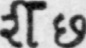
રીંછ
